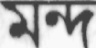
মন্দ
